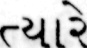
ત્યારે
